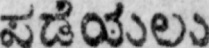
ಪಡೆಯಲು
